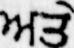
ਅਤੇ
